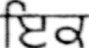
ਇਕ
